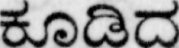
ಕೂಡಿದ
